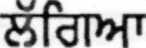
ਲੱਗਿਆ
